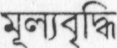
মূল্যবৃদ্ধি
